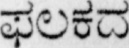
ಫಲಕದ
